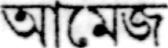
আমেজ
